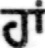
ਹਾਂ
